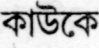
কাউকে
